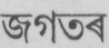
জগতৰ
